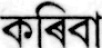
কৰিবা
